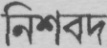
নিশবদ
